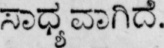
ಸಾಧ್ಯವಾಗಿದೆ.
